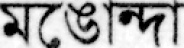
মঙোন্দা
